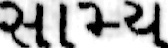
સામ્ય
